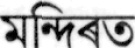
মন্দিৰত
